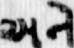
અને
